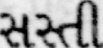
સસ્તી
